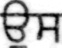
ਉਸ
